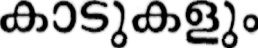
കാടുകളും
